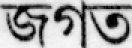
জগত
